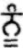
ਨੂੰ
